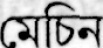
মেচিন
